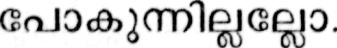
പോകുന്നില്ലല്ലോ.
